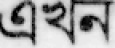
এখন
